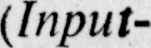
(Input-
